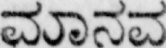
ಮಾನವ
